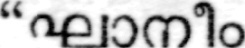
"ഘാനീം
